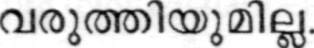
വരുത്തിയുമില്ല.
